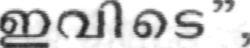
ഇവിടെ",
